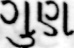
ગુણ
